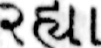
રહ્યા
